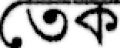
তেক
